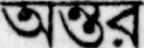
অন্তর
